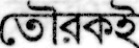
তৌরকই
